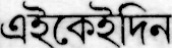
এইকেইদিন
